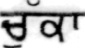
ਚੁੱਕਾ
